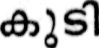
കുടി
